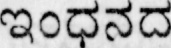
ಇಂಧನದ
